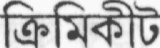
ক্রিমিকীট
